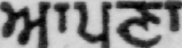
ਆਪਣਾ
